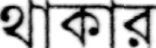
থাকার
